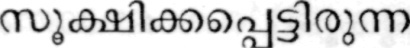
സൂക്ഷിക്കപ്പെട്ടിരുന്ന
